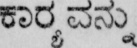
ಕಾರ್‍ಯವನ್ನು
